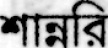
শান্নরি
